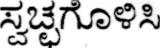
ಸ್ವಚ್ಛಗೊಳಿಸಿ
